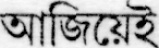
আজিয়েই
